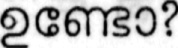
ഉണ്ടോ?
